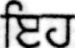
ਇਹ
